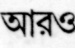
আরও
